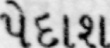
પેદાશ
